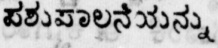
ಪಶುಪಾಲನೆಯನ್ನು
